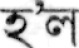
হ'ল
